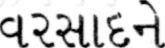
વરસાદને
